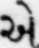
એ
